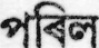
পৰিল
